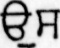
ਉਸ
